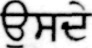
ਉਸਦੇ
